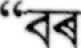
"বৰ
